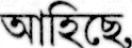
আহিছে,
